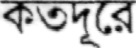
কতদূরে
